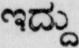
ಇದ್ದು
